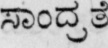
ಸಾಂದ್ರತೆ
